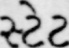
સ્ટેટ
